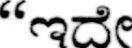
"ಇದೇ
